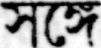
সঙ্গে
